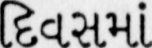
દિવસમાં
